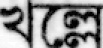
খল্লে
